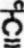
ਨੂੰ
